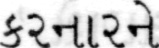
કરનારને
